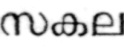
സകല
